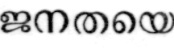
ജനതയെ
